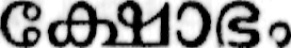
ക്ഷോഭം
